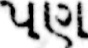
પણ
